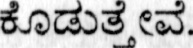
ಕೊಡುತ್ತೇವೆ.
